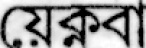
য়েক্নবা
